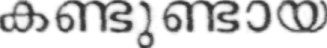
കണ്ടുണ്ടായ
